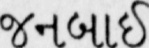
જનબાઈ
